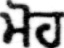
ਮੋਹ
